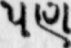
પણ
